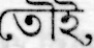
তৌই,
